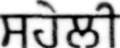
ਸਹੇਲੀ
